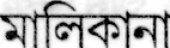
মালিকানা
